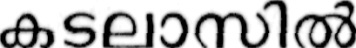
കടലാസില്‍
